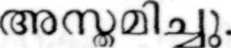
അസ്തമിച്ചു.
